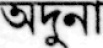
অদুনা
